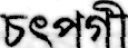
চৎপগী
